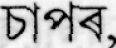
চাপৰ,
